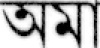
অমা
